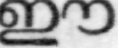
ഈ
